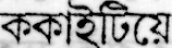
ককাইটিয়ে
